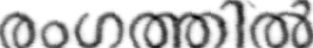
രംഗത്തില്‍
